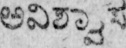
ಅವಿಶ್ವಾಸ
